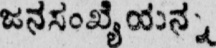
ಜನಸಂಖ್ಯೆಯನ್ನು
